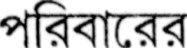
পরিবারের
